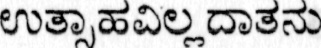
ಉತ್ಸಾಹವಿಲ್ಲದಾತನು
